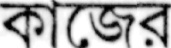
কাজের
